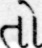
તો
